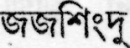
জজশিংদু
